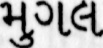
મુગલ
